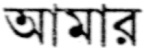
আমার
